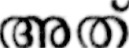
അത്
